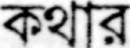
কথার
